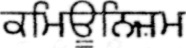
ਕਮਿਊਨਿਜ਼ਮ
